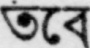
তবে
